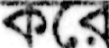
করে
